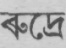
ৰুদ্ৰে
